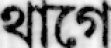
থাগে
